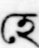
হে
